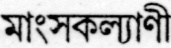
মাংসকল্যাণী
